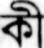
কী
